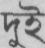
দুই
